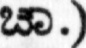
ಚಾ. )
